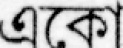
একো
